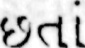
છતાં
